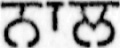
ਨਾਲ
